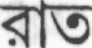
রাত
